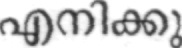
എനിക്കു
